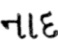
નાદ
